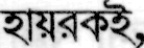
হায়রকই,
